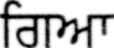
ਗਿਆ
